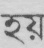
হয়
